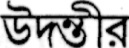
উদন্তীর
